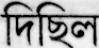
দিছিল
